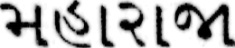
મહારાજા
